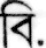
বি.
